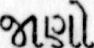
જાણો
